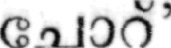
ചോറ്'
